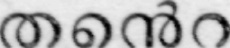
തന്റെ
